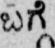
ಬಗ್ಗೆ
